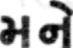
મને
